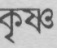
কৃষ্ণ
